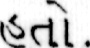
હતો.
